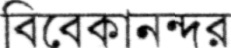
বিবেকানন্দর
